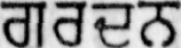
ਗਰਦਨ
